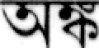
অঙ্ক
